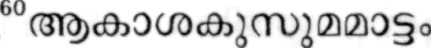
60ആകാശകുസുമമാട്ടം
